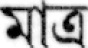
মাত্র
